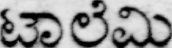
ಟಾಲೆಮಿ
